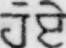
ਹੋਏ
